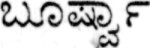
ಬೂರ್ಷ್ವಾ
